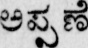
ಅಪ್ಪಣೆ
